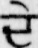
ਦੇ
